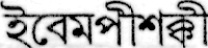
ইবেমপীশক্কী
